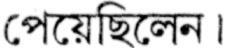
পেয়েছিলেন।
